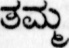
ತಮ್ಮ
